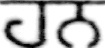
ਹਨ
